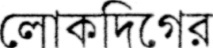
লোকদিগের
